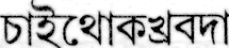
চাইথোকখ্রবদা
